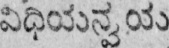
ವಿಧಿಯನ್ವಯ
